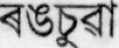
ৰঙচুৱা
